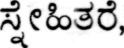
ಸ್ನೇಹಿತರೆ,
